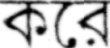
করে
